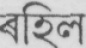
ৰহিল
